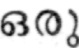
ഒരു
